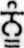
ਨੂੰ
